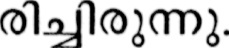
രിച്ചിരുന്നു.
